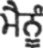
ਮੈਨੂੰ
